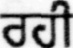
ਰਹੀ
